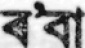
ৰ'বা
